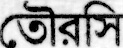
তৌরসি
